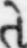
તે
